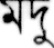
মদু
